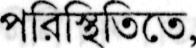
পরিস্থিতিতে,
